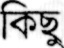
কিছু
